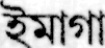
ইমাগা
